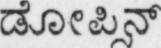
ಡೋಪ್ಸಿನ್
